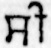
ਸੀ
